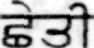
ਛੇਤੀ
